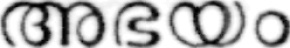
അഭയം
